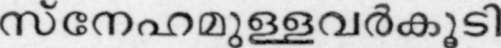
സ്നേഹമുള്ളവര്‍കൂടി
